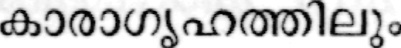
കാരാഗൃഹത്തിലും
